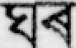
ঘৰ
